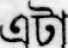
এটা
